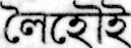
লৈহৌই
